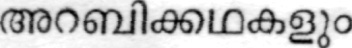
അറബിക്കഥകളും
